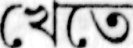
খেতে
